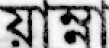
য়াম্না
